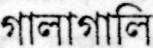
গালাগালি
